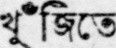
খুঁজিতে
